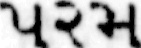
પરમ
